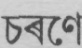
চৰণে
